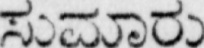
ಸುಮಾರು
